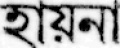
হায়না
